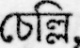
চেল্লি,
